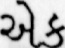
એક
